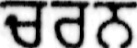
ਚਰਨ
